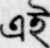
এই
